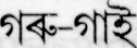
গৰু-গাই
